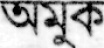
অমুক
